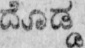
ದೊಡ್ಡ
